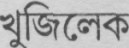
খুজিলেক
